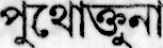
পুথোক্তুনা
